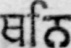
ਥਨਿ
